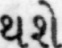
થશે
